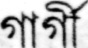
গার্গী
